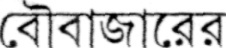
বৌবাজারের
